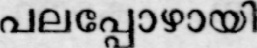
പലപ്പോഴായി
